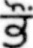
ਭੌਂ
